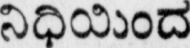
ನಿಧಿಯಿಂದ
